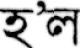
হ'ল
